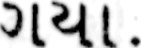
ગયા.
